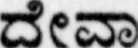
ದೇವಾ
